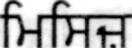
ਮਿਸਿਜ਼
